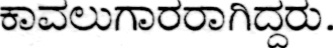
ಕಾವಲುಗಾರರಾಗಿದ್ದರು.
